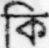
কি
